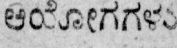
ಆಯೋಗಗಳು
